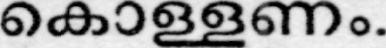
കൊള്ളണം.
